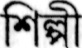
শিল্পী
